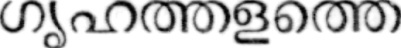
ഗൃഹത്തളത്തെ
